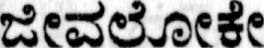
ಜೀವಲೋಕೇ
